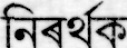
নিৰর্থক
